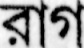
রাগ
